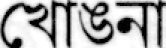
খোঙনা
